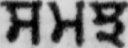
ਸਮਝ
